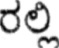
ರಲ್ಲಿ
